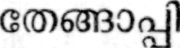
തേങ്ങാപ്പി
